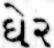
ઘેર
